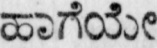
ಹಾಗೆಯೇ
